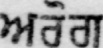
ਅਰੋਗ
